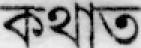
কথাত
